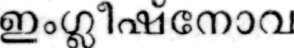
ഇംഗ്ലീഷ്നോവ
